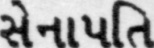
સેનાપતિ
